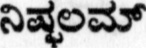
ನಿಷ್ಫಲಮ್
